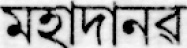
মহাদানৱ
